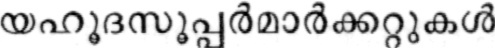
യഹൂദസൂപ്പര്‍മാര്‍ക്കറ്റുകള്‍
